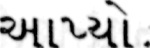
આપ્યો.
